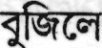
বুজিলে
